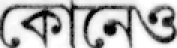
কোনেও
